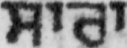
ਸਾਰਾ
